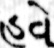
હવે
